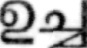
ഉച്ച
